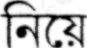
নিয়ে
